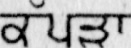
ਕੱਪੜਾ
